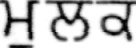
ਮੁਲਕ
